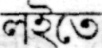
লইতে
